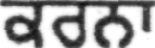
ਕਰਨਾ
